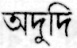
অদুদি
